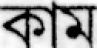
কাম
